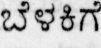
ಬೆಳಕಿಗೆ
